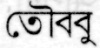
তৌববু
